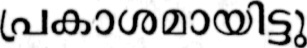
പ്രകാശമായിട്ടു
